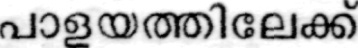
പാളയത്തിലേക്ക്
